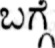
ಬಗ್ಗೆ
